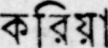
করিয়া
